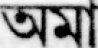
অমা
